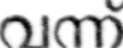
വന്ന്
